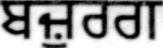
ਬਜ਼ੁਰਗ
